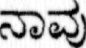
ನಾವು
